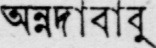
অন্নদাবাবু
